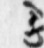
કે
